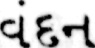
વંદન
